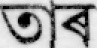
তাৰ
